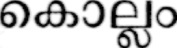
കൊല്ലം
